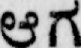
ಆಗ
